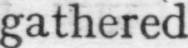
gathered
